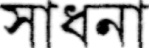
সাধনা
